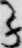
કે
